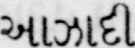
આઝાદી
